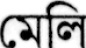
মেলি
